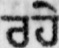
ਰਹੇ
